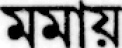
মমায়
